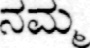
ನಮ್ಮ
